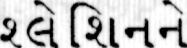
શ્લેશિનને
